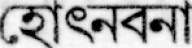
হোৎনবনা
